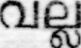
വല്ല
